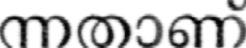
ന്നതാണ്
